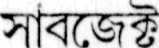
সাবজেক্ট
